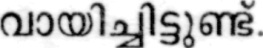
വായിച്ചിട്ടുണ്ട്.
